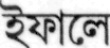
ইফালে
